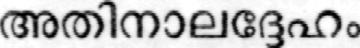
അതിനാലദ്ദേഹം
